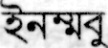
ইনম্মবু
